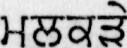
ਮਲਕੜੇ
